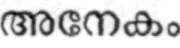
അനേകം
